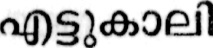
എട്ടുകാലി
